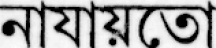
নাযায়তো
